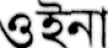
ওইনা
